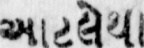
આટલેથી
